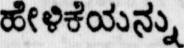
ಹೇಳಿಕೆಯನ್ನು
